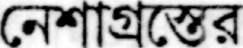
নেশাগ্রস্তের
